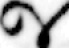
જ
